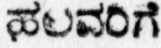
ಹಲವರಿಗೆ
